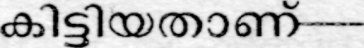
കിട്ടിയതാണ്-
